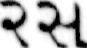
રસ
